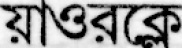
য়াওরক্লে
